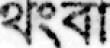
থংবা
